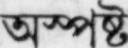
অম্পষ্ট
